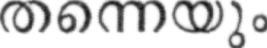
തന്നെയും
